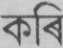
কৰি
